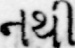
નથી
